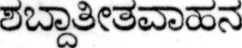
ಶಬ್ದಾತೀತವಾಹನ
